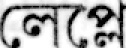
লেপ্লে
